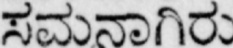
ಸಮನಾಗಿರು
